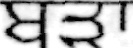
ਬੜਾ
